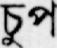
চুপ
